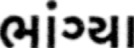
ભાંગ્યા
